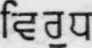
ਵਿਰੁਧ
